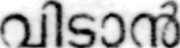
വിടാന്‍
